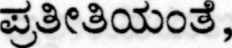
ಪ್ರತೀತಿಯಂತೆ,
